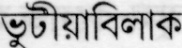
ভুটীয়াবিলাক
